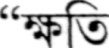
“ক্ষতি
